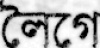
লৈগে
